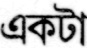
একটা
